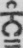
ਨੂੰ
